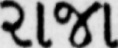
રાજા
